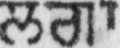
ਲਗਾ
